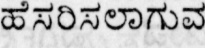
ಹೆಸರಿಸಲಾಗುವ
